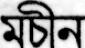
মচীন
